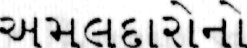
અમલદારોનો
